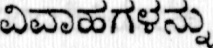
ವಿವಾಹಗಳನ್ನು
